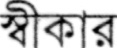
স্বীকার
